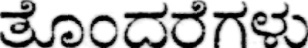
ತೊಂದರೆಗಳು
